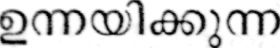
ഉന്നയിക്കുന്ന
